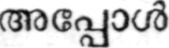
അപ്പോള്‍
